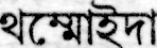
থম্মোইদা
